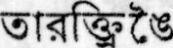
তারক্ত্রিঙৈ
